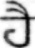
ਹੈ
